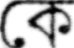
কে
